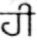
ਹੀ
